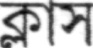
ক্লাস
